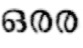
ഒരര
